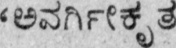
‘ಅವರ್ಗೀಕೃತ
